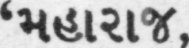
'મહારાજ,
